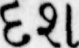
દશ
